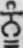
ਨੂੰ
